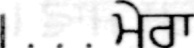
।..ਮੇਰਾ
